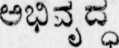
ಅಭಿವೃದ್ಧ
